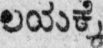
ಲಯಕ್ಕೆ
